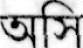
অসি
